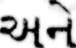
અને
